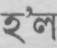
হ'ল
